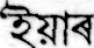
'ইয়াৰ
